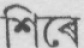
শিৰে
